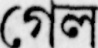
গেল
